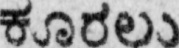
ಕೂರಲು
